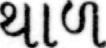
થાળ
